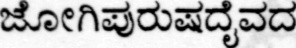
ಜೋಗಿಪುರುಷದೈವದ
